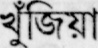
খুঁজিয়া
